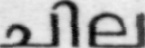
ചില
